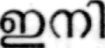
ഇനി
